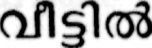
വീട്ടില്‍
